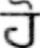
ਹੋ
